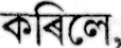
কৰিলে,
